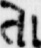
તો
